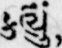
કહ્યું,
